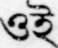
ওই
